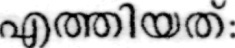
എത്തിയത്:
